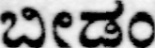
ಬೀಡಂ
